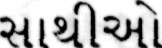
સાથીઓ
